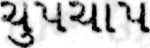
ચુપચાપ
